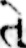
તે
